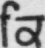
ਕਿ
